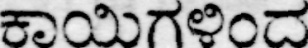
ಕಾಯಿಗಳಿಂದ
